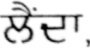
ਲੈਂਦਾ,
